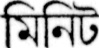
মিনিট
